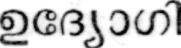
ഉദ്യോഗി
